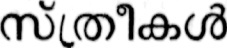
സ്ത്രീകള്‍
